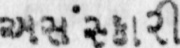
અસંસ્કારી
